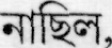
নাছিল,
